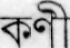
কণী
